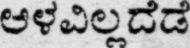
ಆಳವಿಲ್ಲದೆಡೆ
